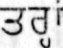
ਤਰ੍ਹਾਂ
